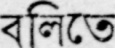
বলিতে
